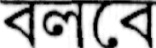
বলবে
